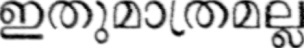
ഇതുമാത്രമല്ല
